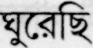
ঘুরেছি
